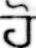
ਹੋ
